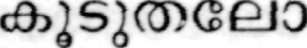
കൂടുതലോ
